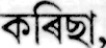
কৰিছা,
